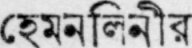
হেমনলিনীর
